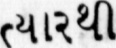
ત્યારથી
